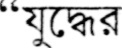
“যুদ্ধের
